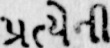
પ્રત્યેની
